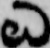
ಎ
